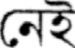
নেই
